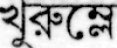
খুরুম্লে
